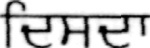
ਦਿਸਦਾ
